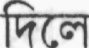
দিলে
